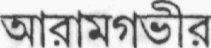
আরামগভীর
